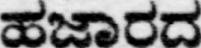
ಹಜಾರದ
